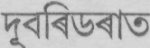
দূবৰিডৰাত
